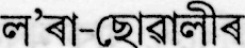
ল'ৰা-ছোৱালীৰ
